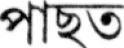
পাছত
